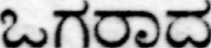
ಒಗರಾದ
